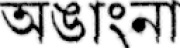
অঙাংনা
